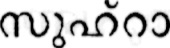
സുഹ്റാ
